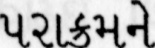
પરાક્રમને
